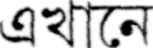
এখানে
